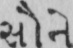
સૌને
